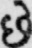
છે
